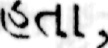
હતા,
